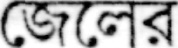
জেলের
